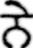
ਨੇ
